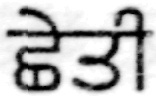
ਛੇਤੀ
